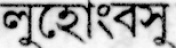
লুহোংবসু
